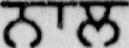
ਨਾਲ
